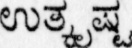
ಉತ್ಕೃಷ್ಟ
